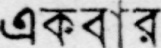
একবার
